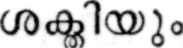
ശക്തിയും
